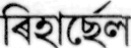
ৰিহাৰ্ছেল
